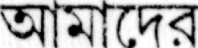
আমাদের
